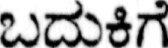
ಬದುಕಿಗೆ
